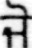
ਜੋ
